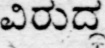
ವಿರುದ್ಧ
